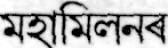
মহামিলনৰ
